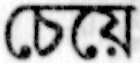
চেয়ে
